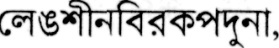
লেঙশীনবিরকপদুনা,
